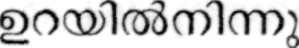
ഉറയില്‍നിന്നു
